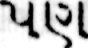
પણ
